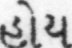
હોય
